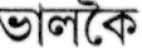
ভালকৈ
